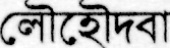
লৌহৌদবা
